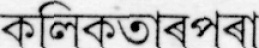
কলিকতাৰপৰা
